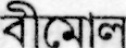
বীমোল
